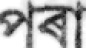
পৰা
